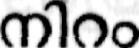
നിറം
